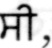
ਸੀ,
